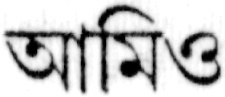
আমিও
